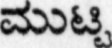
ಮುಟ್ಟಿ
